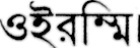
ওইরম্মি।
